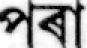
পৰা
